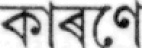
কাৰণে
